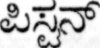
ಪಿಸ್ಟನ್
